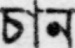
চান
